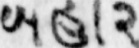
બહાર
